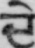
ਦੇ
